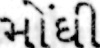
મોંઘી
